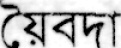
য়ৈবদা
